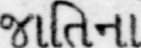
જાતિના
